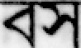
বস
